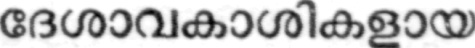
ദേശാവകാശികളായ
